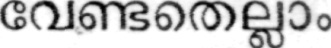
വേണ്ടതെല്ലാം
